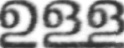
ഉള്ള
